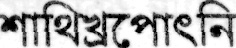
শাথিখ্রপোৎনি
